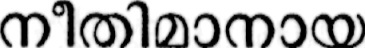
നീതിമാനായ
